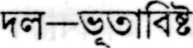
দল—ভূতাবিষ্ট
